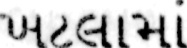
ખટલામાં
